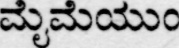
ಮೈಮೆಯುಂ
